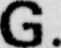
G.
